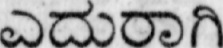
ಎದುರಾಗಿ
